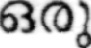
ഒരു
